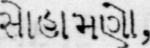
સોહામણો,
